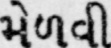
મેળવી
